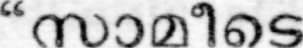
"സാമീടെ
